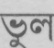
ভুল
